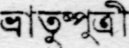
ভ্রাতুষ্পুত্রী
